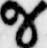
જ
